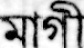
মাগী
